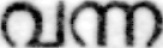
വന്ന
